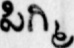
ಪಿಗ್ಮಿ
